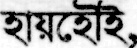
হায়হৌই,
